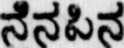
ನೆನಪಿನ
